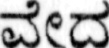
ವೇದ
